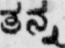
ತನ್ನ
